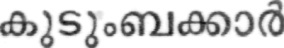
കുടുംബക്കാര്‍
